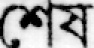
শেষ
